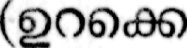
(ഉറക്കെ
